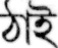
ঠাই
